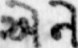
એને
